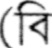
(বি
